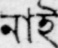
নাই
